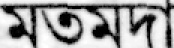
মতমদা
